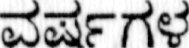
ವರ್ಷಗಳ
